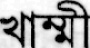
খাম্মী
